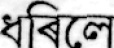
ধৰিলে
